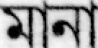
মানা
